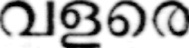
വളരെ
